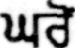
ਘਰੋਂ
